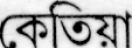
কেতিয়া
